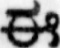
ಈ
